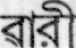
ৱারী
